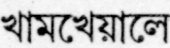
খামখেয়ালে
